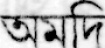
অমদি
